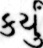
કર્યું
